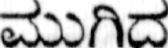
ಮುಗಿದ
